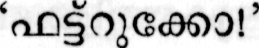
'ഫട്ട്റുക്കോ!'
